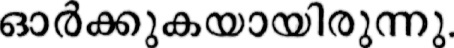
ഓര്‍ക്കുകയായിരുന്നു.
